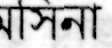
মসিনা
